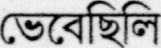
ভেবেছিলি
